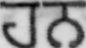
ਹਨ
